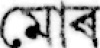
মোৰ
